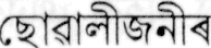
ছোৱালীজনীৰ
